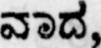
ವಾದ,
